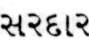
સરદાર
